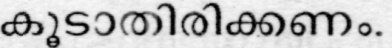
കൂടാതിരിക്കണം.
